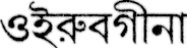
ওইরুবগীনা
